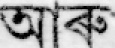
আৰু
